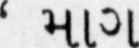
'માગ
